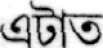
এটাত
